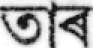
তাৰ
